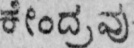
ಕೇಂದ್ರವು
